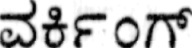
ವರ್ಕಿಂಗ್
